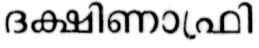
ദക്ഷിണാഫ്രി
